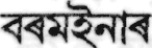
বৰমইনাৰ
